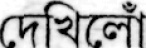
দেখিলোঁ
